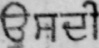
ਉਸਦੀ
